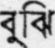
বুঝি
